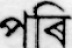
পৰি
